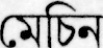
মেচিন
